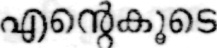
എന്റെകൂടെ
